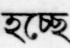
হচ্ছে
